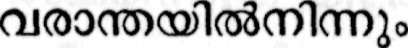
വരാന്തയില്‍നിന്നും
